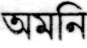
অমনি
